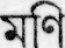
মণি
